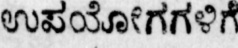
ಉಪಯೋಗಗಳಿಗೆ
